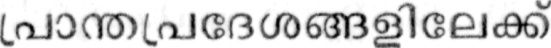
പ്രാന്തപ്രദേശങ്ങളിലേക്ക്
